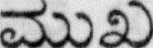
ಮುಖ
